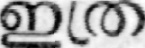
ഇത്ര
